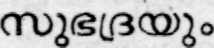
സുഭദ്രയും
